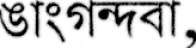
ঙাংগন্দবা,
